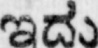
ಇದು
